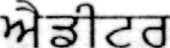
ਐਡੀਟਰ
